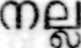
നല്ല
